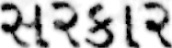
સરકાર
